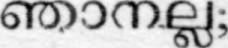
ഞാനല്ല;
